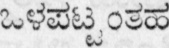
ಒಳಪಟ್ಟಂತಹ
